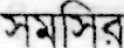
সমসির
